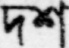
দশ
